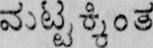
ಮಟ್ಟಕ್ಕಿಂತ
